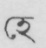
হে
